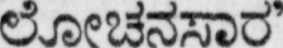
ಲೋಚನಸಾರ’
